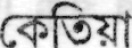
কেতিয়া
